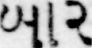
બાર
